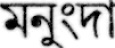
মনুংদা
